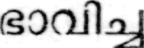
ഭാവിച്ച
